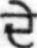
ਦੇ
